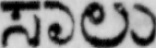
ಸಾಲು
